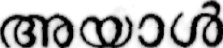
അയാള്‍
